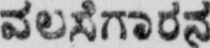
ವಲಸೆಗಾರನ
